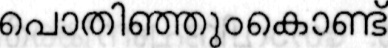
പൊതിഞ്ഞുംകൊണ്ട്
